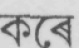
কৰে
